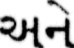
અને
